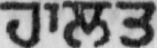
ਹਾਲਤ
